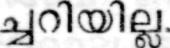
ച്ചറിയില്ല.
